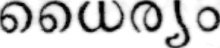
ധൈര്യം
